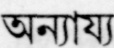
অন্যায্য
